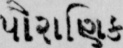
પૌરાણિક
